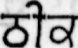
ਠੀਕ
